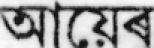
আয়েৰ
